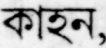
কাহন,
